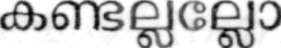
കണ്ടല്ലല്ലോ
